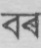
বৰ
